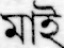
মাই
